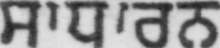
ਸਾਧਾਰਨ
